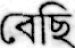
বেছি
